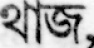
থাজ,
